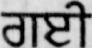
ਗਈ
